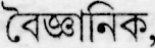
বৈজ্ঞানিক,
